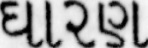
ઘારણ
